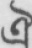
ঐ
